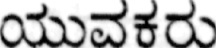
ಯುವಕರು
